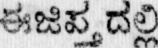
ಈಜಿಪ್ತದಲ್ಲಿ
